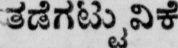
ತಡೆಗಟ್ಟುವಿಕೆ
